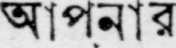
আপনার
